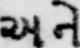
અને
